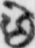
છે
